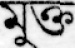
মুক্ত
